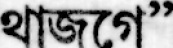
থাজগে”
